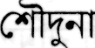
শৌদুনা
